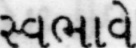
સ્વભાવે
